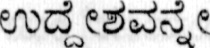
ಉದ್ದೇಶವನ್ನೇ
